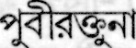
পুবীরক্তুনা
